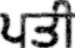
ਪਤੀ
